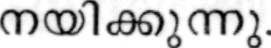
നയിക്കുന്നു.
